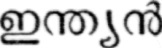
ഇന്ത്യന്‍
